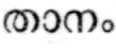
താനം
